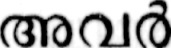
അവര്‍
